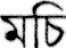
মচি
